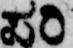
ಪರಿ
